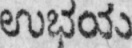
ಉಭಯ
